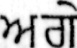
ਅਗੇ
